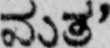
ಮತ’
